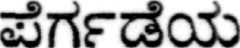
ಪೆರ್ಗಡೆಯ
